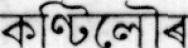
কণ্টিলৌৰ
